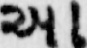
આ
